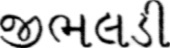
જીભલડી
